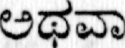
ಅಥವಾ
